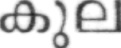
കുല
